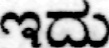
ಇದು
